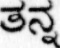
ತನ್ನ
